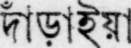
দাঁড়াইয়া
